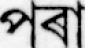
পৰা
